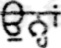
ਉਨ੍ਹਾਂ
